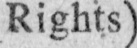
Rights)
